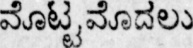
ಮೊಟ್ಟಮೊದಲು
